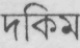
দকিম
